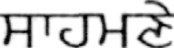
ਸਾਹਮਣੇ
